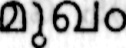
മുഖം
